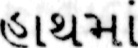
હાથમાં
